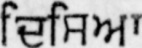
ਦਿਸਿਆ
